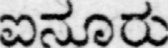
ಐನೂರು
